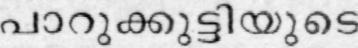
പാറുക്കുട്ടിയുടെ
